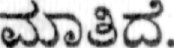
ಮಾತಿದೆ.
